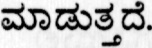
ಮಾಡುತ್ತದೆ.
